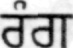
ਰੰਗ
